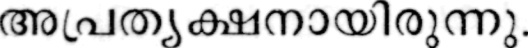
അപ്രത്യക്ഷനായിരുന്നു.
